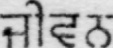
ਜੀਵਨ
